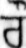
ਰੌ
